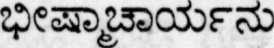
ಭೀಷ್ಮಾಚಾರ್ಯನು
